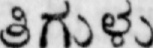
ತಿಗುಳು
